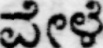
ವೇಳೆ
